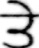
ਤੇ
